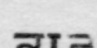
ਭਾਵ
